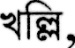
খল্লি,
